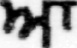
ਆ
